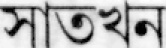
সাতখন
